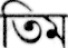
তিম
